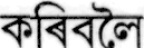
কৰিবলৈ
